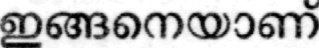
ഇങ്ങനെയാണ്
